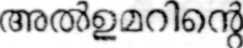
അല്‍ഉമറിന്റെ
